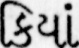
કિયાં
